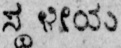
ಸ್ಥಳೀಯ
